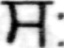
ਸ:
